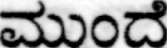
ಮುಂದೆ
